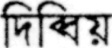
দিব্বিয়
